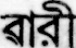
ৱারী
